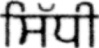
ਸਿੱਧੀ
